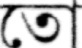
তো
